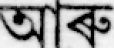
আৰু
